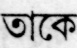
তাকে
